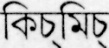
কিচ্‌মিচ্
